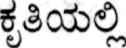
ಕೃತಿಯಲ್ಲಿ
